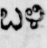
ಬಳಿ
